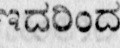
ಇದರಿಂದ
